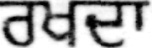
ਰਖਦਾ
